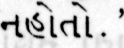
નહોતો.'
